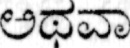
ಅಥವಾ
